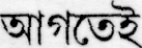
আগতেই
